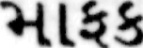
માફક
